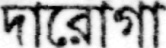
দারোগা
